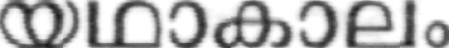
യഥാകാലം
